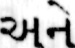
અને
